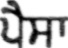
ਪੈਸਾ
